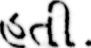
હતી.
